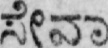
ಸೇವಾ
